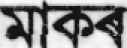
মাকৰ
